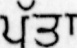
ਪੱਤਾ
